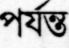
পর্যন্ত
